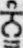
ਨੂੰ
